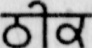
ਠੀਕ
